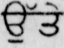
ਉੱਤੇ
